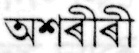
অশৰীৰী
